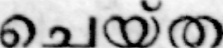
ചെയ്ത
